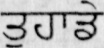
ਤੁਹਾਡੇ
